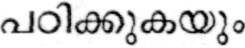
പഠിക്കുകയും
